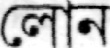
লোন
